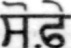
ਸੋਫ਼ੇ
